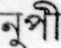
নুপী
